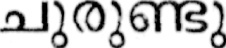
ചുരുണ്ടു
